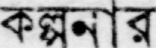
কল্পনার
